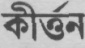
কীৰ্ত্তন
